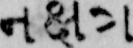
નક્ષત્ર
